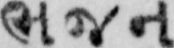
ભજન
